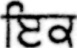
ਇਕ
